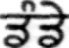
ਡੰਡੇ
